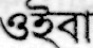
ওইবা
